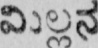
ಮಿಲ್ಲನ
